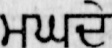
ਮਘਦੇ
